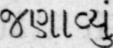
જણાવ્યું
